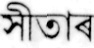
সীতাৰ
